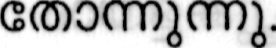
തോന്നുന്നു.
